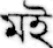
মই
